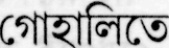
গোহালিতে
